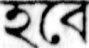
হবে
